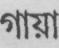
গায়া
